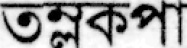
তম্লকপা
